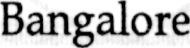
Bangalore
